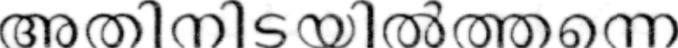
അതിനിടയില്‍ത്തന്നെ
